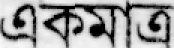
একমাত্র
